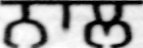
ਨਾਲ
